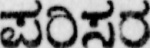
ಪರಿಸರ
